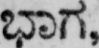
ಭಾಗ,
